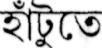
হাঁটুতে
